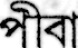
পীবা
